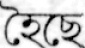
হৈছে
